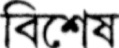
বিশেষ
